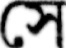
সে
